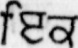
ਇਕ
